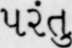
પરંતુ
